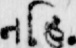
નહિ.
